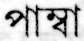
পাম্বা
